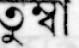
তুম্বা
